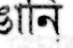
ঙানি
